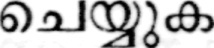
ചെയ്യുക
